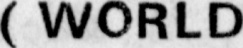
(WORLD
